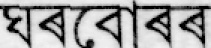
ঘৰবোৰৰ
